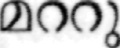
മററു
